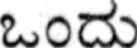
ಒಂದು
